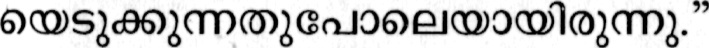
യെടുക്കുന്നതുപോലെയായിരുന്നു.”
